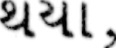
થયા,
